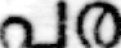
പര
